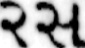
રસ
